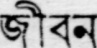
জীবন
